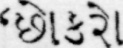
'છોકરો
